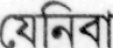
যেনিবা
